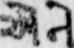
એને
